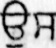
ਉਸ
